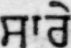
ਸਾਰੇ
